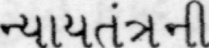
ન્યાયતંત્રની
